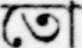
তো
